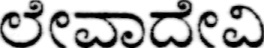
ಲೇವಾದೇವಿ
